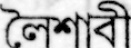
লৈশাবী
